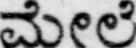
ಮೇಲೆ
